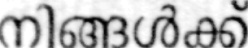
നിങ്ങള്‍ക്ക്
